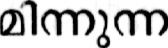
മിന്നുന്ന
